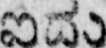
ಐದು
